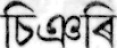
চিঞৰি
